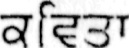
ਕਵਿਤਾ
